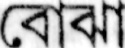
বোঝা
